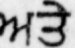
ਅਤੇ
